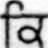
ਕਿ
